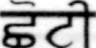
ਛੋਟੀ
